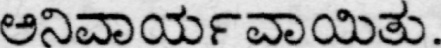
ಅನಿವಾರ್ಯವಾಯಿತು.
